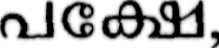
പക്ഷേ,
